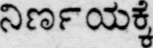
ನಿರ್ಣಯಕ್ಕೆ
